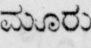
ಮೂರು
